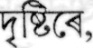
দৃষ্টিৰে,
